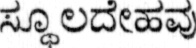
ಸ್ಥೂಲದೇಹವು
